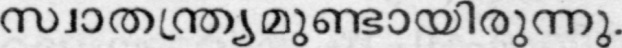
സ്വാതന്ത്ര്യമുണ്ടായിരുന്നു.
